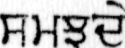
ਸਮਝਦੇ
